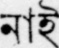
নাই
